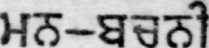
ਮਨ-ਬਚਨੀ
